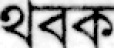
থবক
